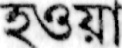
হওয়া
